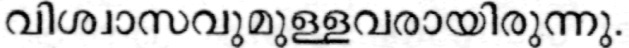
വിശ്വാസവുമുള്ളവരായിരുന്നു.
